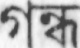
গন্ধ
